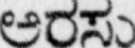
ಅರಸು
